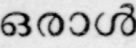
ഒരാള്‍
